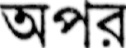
অপর
